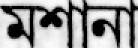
মশানা
